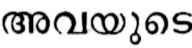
അവയുടെ
